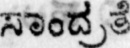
ಸಾಂದ್ರತೆ
